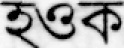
হওক
